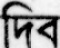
দিব
